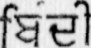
ਬਿੰਦੀ
